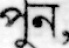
পুন,
